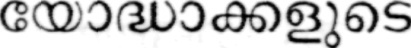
യോദ്ധാക്കളുടെ
